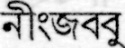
নীংজববু
